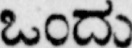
ಒಂದು
